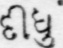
દીધું
